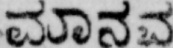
ಮಾನವ
